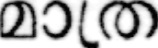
മാത്ര
